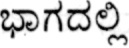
ಭಾಗದಲ್ಲಿ
